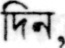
দিন,
